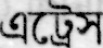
এট্রেস
